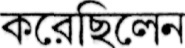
করেছিলেন
